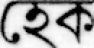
হেক
